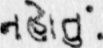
નહોતું.
